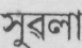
সুৱলা
